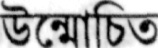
উন্মোচিত
